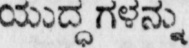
ಯುದ್ಧಗಳನ್ನು
